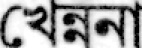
খেন্ননা
